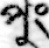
পুং
